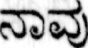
ನಾವು
